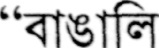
“বাঙালি
